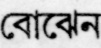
বোঝেন
